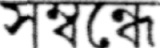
সম্বন্ধে
